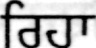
ਰਿਹਾ
